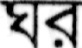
ঘর
